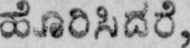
ಹೊರಿಸಿದರೆ,
